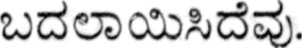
ಬದಲಾಯಿಸಿದೆವು.
